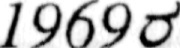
1969ರ
